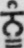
ਨੂੰ
